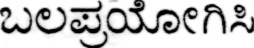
ಬಲಪ್ರಯೋಗಿಸಿ
